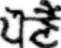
ਪੌਣੈਂ
